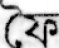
ফৈ
